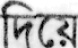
দিয়ে
